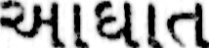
આઘાત
